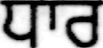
ਧਾਰ
